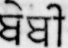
ਬੇਬੀ
